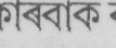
কাৰবাক
